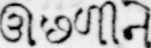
ઊછળીને
